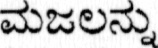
ಮಜಲನ್ನು
